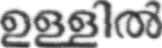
ഉള്ളില്‍
